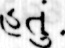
હતું.
